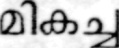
മികച്ച
